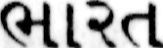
ભારત
